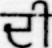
ਦੀ
